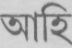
আহি
